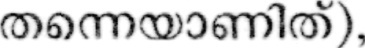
തന്നെയാണിത്),
